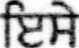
ਇਸੇ
